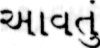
આવતું
